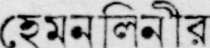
হেমনলিনীর
